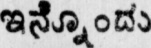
ಇನ್ನೊಂದು
